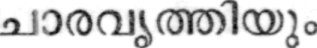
ചാരവൃത്തിയും
